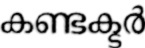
കണ്ടക്ടര്‍
